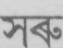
সৰু
